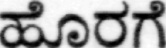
ಹೊರಗೆ
